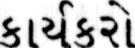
કાર્યકરો
